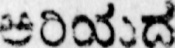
ಅರಿಯದ
